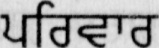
ਪਰਿਵਾਰ
